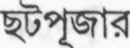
ছটপূজার
